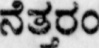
ನೆತ್ತರಂ
